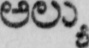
ಅಲ್ಯು
